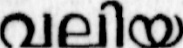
വലിയ
